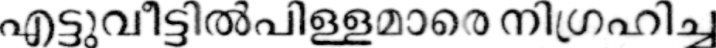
എട്ടുവീട്ടില്‍പിള്ളമാരെനിഗ്രഹിച്ച
